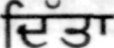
ਦਿੱਤਾ
